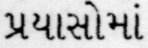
પ્રયાસોમાં
